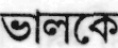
ভালকে
